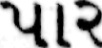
પાર
